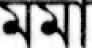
মমা
